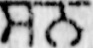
ਸਨ
